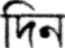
দিন
